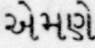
એમણે
